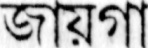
জায়গা
